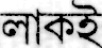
লাকই
